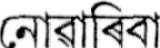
নোৱাৰিবা
